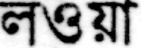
লওয়া
